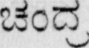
ಚಂದ್ರ
